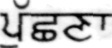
ਪੁੱਛਣਾ
